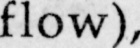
Flow),
